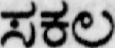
ಸಕಲ
